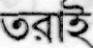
তরাই
